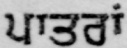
ਪਾਤਰਾਂ
